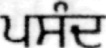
ਪਸੰਦ
